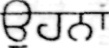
ਉਹਨਾਂ
